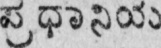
ಪ್ರಧಾನಿಯ
